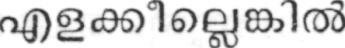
എളക്കീല്ലെങ്കില്‍
